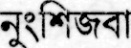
নুংশিজবা
